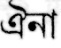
ঐনা
